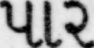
પાર
